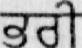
ਭਰੀ
